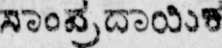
ಸಾಂಪ್ರದಾಯಿಕ
